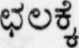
ಛಲಕ್ಕೆ
